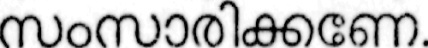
സംസാരിക്കണേ.
